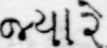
જ્યારે
